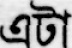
এটা
